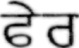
ਫੇਰ
